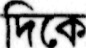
দিকে
